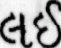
લઈ
